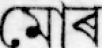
মোৰ
